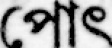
পোৎ
